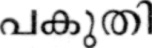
പകുതി
